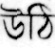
উঠি
